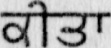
ਕੀਤਾ
